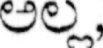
ಅಲ್ಲ,
